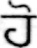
ਹੋ
